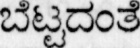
ಬೆಟ್ಟದಂತೆ
